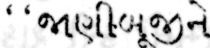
"જાણીબૂજીને
